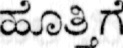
ಹೊತ್ತಿಗೆ
